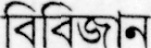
বিবিজান
